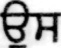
ਉਸ
